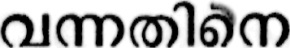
വന്നതിനെ
